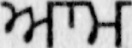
ਆਮ
